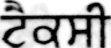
ਟੈਕਸੀ
